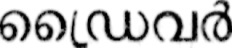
ഡ്രൈവര്‍
